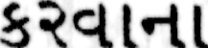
કરવાના
